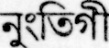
নুংতিগী
